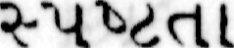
સ્પષ્ટતા
